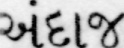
અંદાજ
